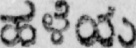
ಹಳೆಯ
